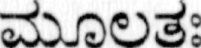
ಮೂಲತಃ
